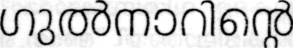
ഗുല്‍നാറിന്റെ
